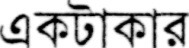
একটাকার
